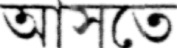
আসতে
